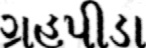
ગ્રહપીડા
